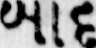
બાદ
